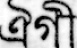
ঐগী
